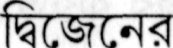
দ্বিজেনের
